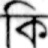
কি
